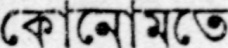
কোনোমতে
